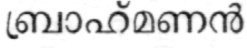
ബ്രാഹ്മണന്‍
